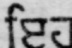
ਇਹ
